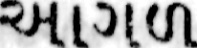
આગળ
